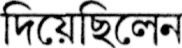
দিয়েছিলেন
